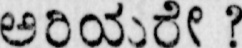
ಅರಿಯರೇ?
